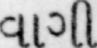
વાગી
